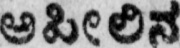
ಅಪೀಲಿನ
